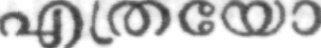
എത്രയോ
